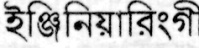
ইঞ্জিনিয়ারিংগী
